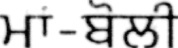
ਮਾਂ-ਬੋਲੀ
